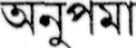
অনুপমা
